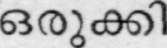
ഒരുക്കി
